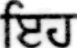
ਇਹ
